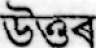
উত্তৰ
